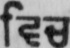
ਵਿਚ
